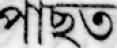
পাছত
